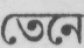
তেনে
